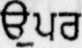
ਉਪਰ
